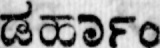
ಡರ್ಹಾಂ
